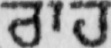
ਰਾਹ
